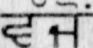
ਵੱਜੋਂ
